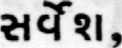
સર્વેશ,
